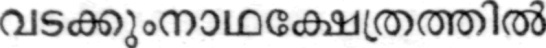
വടക്കുംനാഥക്ഷേത്രത്തില്‍
